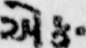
એક-
